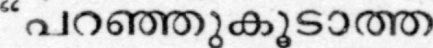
"പറഞ്ഞുകൂടാത്ത
